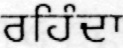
ਰਹਿੰਦਾ
